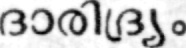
ദാരിദ്ര്യം
